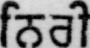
ਨਿਰੀ
